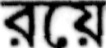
রয়ে
